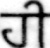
ਹੀ
